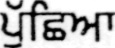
ਪੁੱਛਿਆ
